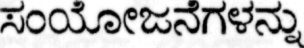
ಸಂಯೋಜನೆಗಳನ್ನು
